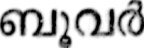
ബൂവര്‍
